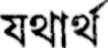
যথার্থ
